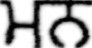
ਮਨ
